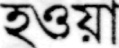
হওয়া
